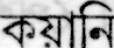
কয়ানি
